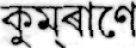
কুম্‌ৰাণে
